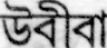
উবীবা
